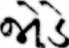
જોડે
